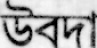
উবদা
